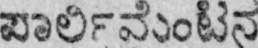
ಪಾರ್ಲಿಮೆಂಟಿನ
